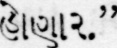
હોણાર."
